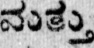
ಮತ್ತು
